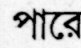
পারে
